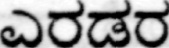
ಎರಡರ
